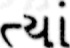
ત્યાં
